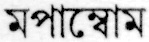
মপাম্বোম
